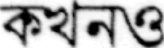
কখনও
